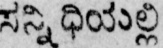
ಸನ್ನಿಧಿಯಲ್ಲಿ
